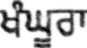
ਖੰਘੂਰਾ
